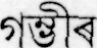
গম্ভীৰ
